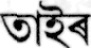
তাইৰ
